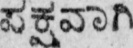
ಪಕ್ಷವಾಗಿ
